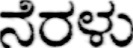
ನೆರಳು
